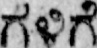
ಗಳಿಗೆ
